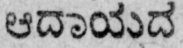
ಆದಾಯದ
